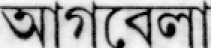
আগবেলা
